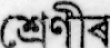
শ্রেণীৰ
